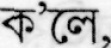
ক'লে,
